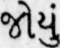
જોયું
